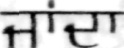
ਜਾਂਦਾ
